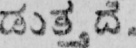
ಡುತ್ತದೆ.
